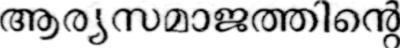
ആര്യസമാജത്തിന്റെ
